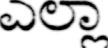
ಎಲ್ಲಾ
